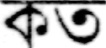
কত
